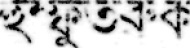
হুম্ফুতরুক
